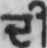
ਦੀ
